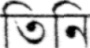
তিনি
